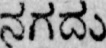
ನಗದು
